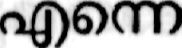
എന്നെ
